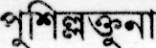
পুশিল্লক্তুনা
